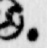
છે.
